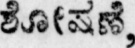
ಶೋಷಣೆ,
